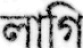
লাগি
